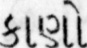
કાણો
